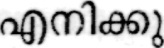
എനിക്കു
